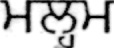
ਮਲ੍ਹਮ
